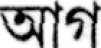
আগ
